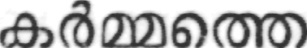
കര്‍മ്മത്തെ
